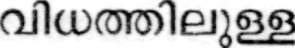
വിധത്തിലുള്ള
